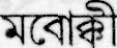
মবোক্কী
